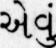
એવું
